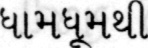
ધામધૂમથી
